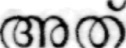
അത്
